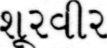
શૂરવીર
